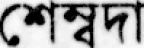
শেম্বদা
